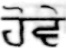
ਹੋਵੇ
